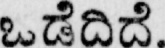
ಒಡೆದಿದೆ.
